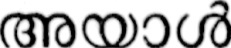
അയാള്‍
